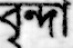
বৃন্দা
